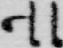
ના
